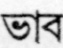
ভাব
